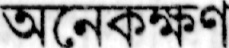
অনেকক্ষণ
